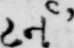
ટર્ન'
